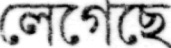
লেগেছে
